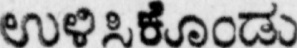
ಉಳಿಸಿಕೊಂಡು
